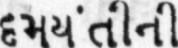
દમયંતીની
